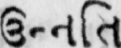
ઉન્નતિ
